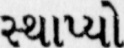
સ્થાપ્યો
